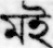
মই
